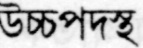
উচ্চপদস্থ
